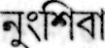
নুংশিবা
